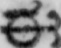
ಈ
